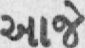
આજે
